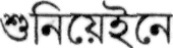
শুনিয়েইনে
